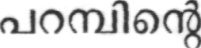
പറമ്പിന്റെ
